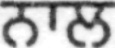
ਨਾਲ
